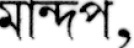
মান্দপ,
